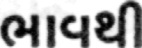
ભાવથી
